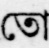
তো
